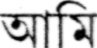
আমি
